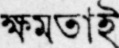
ক্ষমতাই
